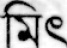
মিৎ
